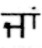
ਜਾਂ
